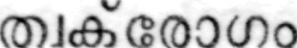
ത്വക്രോഗം
